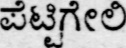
ಪೆಟ್ಟಿಗೇಲಿ
